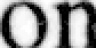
of
